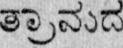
ತ್ರಾಮದ
